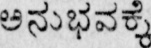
ಅನುಭವಕ್ಕೆ
